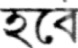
হবে
